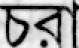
চরা
